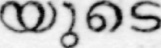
യുടെ
